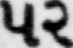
પર
